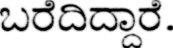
ಬರೆದಿದ್ದಾರೆ.
